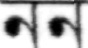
নন
